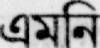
এমনি
